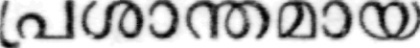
പ്രശാന്തമായ
